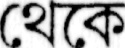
থেকে
